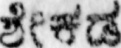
ಶೇಕಡ
